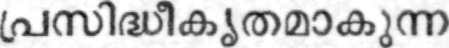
പ്രസിദ്ധീകൃതമാകുന്ന
